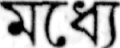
মধ্যে
